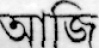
আজি
